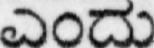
ಎಂದು
